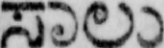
ಸಾಲು
